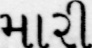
મારી
